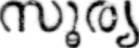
സൂര്യ
